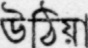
উঠিয়া
